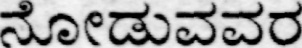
ನೋಡುವವರ
